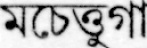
মচেত্তুগা
